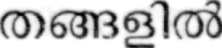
തങ്ങളില്‍
